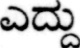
ಎದ್ದು
